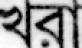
খরা
